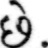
છે.
